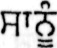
ਸਾਨੂੰ
